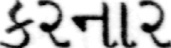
કરનાર
